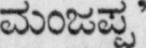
ಮಂಜಪ್ಪ’
